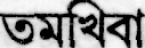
তমখিবা
